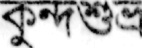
কুন্দশুভ্র
